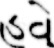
હવે
